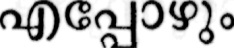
എപ്പോഴും
